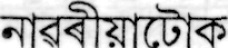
নাৱৰীয়াটোক
